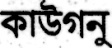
কাউগনু
